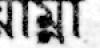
য়াম্না
